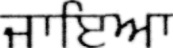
ਜਾਇਆ
